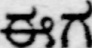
ಈಗ
